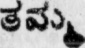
ತಮ್ಮ
